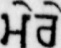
ਮੇਰੇ
